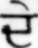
ਦੇ
